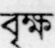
বৃক্ষ
